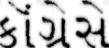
કોંગ્રેસે
